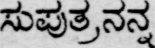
ಸುಪುತ್ರನನ್ನ
